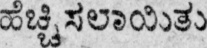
ಹೆಚ್ಚಿಸಲಾಯಿತು
